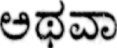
ಅಥವಾ
